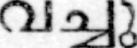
വച്ചു
